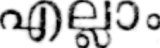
എല്ലാം
